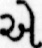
એ
